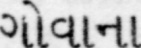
ગોવાના
